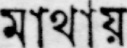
মাথায়
